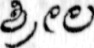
ಶ್ರೀಲ
